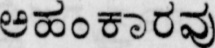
ಅಹಂಕಾರವು
